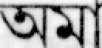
অমা
